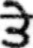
ਤੇ
